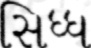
સિધ્ધ
